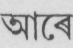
আৰে
